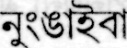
নুংঙাইবা
